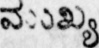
ಮುಖ್ಯ
